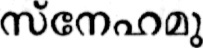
സ്നേഹമു
